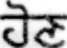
ਹੋਣ
